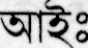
আইঃ
